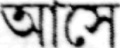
আসে
